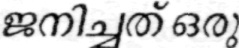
ജനിച്ചത്ഒരു
